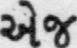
એજ
